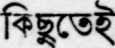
কিছুতেই
